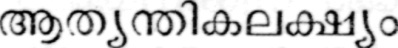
ആത്യന്തികലക്ഷ്യം
